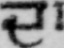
ਦਾ
